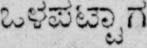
ಒಳಪಟ್ಟಾಗ
